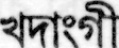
খদাংগী
